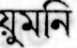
য়ুমনি
